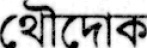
থৌদোক
